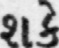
શકે
